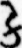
કે
